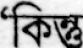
'কিন্তু
